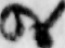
જ
